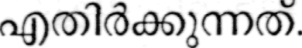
എതിര്‍ക്കുന്നത്.
